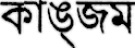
কাঙ্জম
